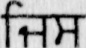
ਜਿਸ
